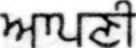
ਆਪਣੀ
